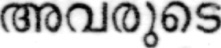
അവരുടെ
